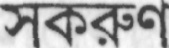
সকরুণ
